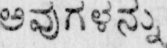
ಅವುಗಳನ್ನು
